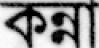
কন্না
